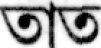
তাত
